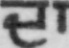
ਦਾ
